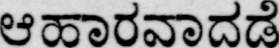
ಆಹಾರವಾದಡೆ
